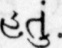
હતું.
